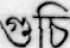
গুচি
